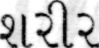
શરીર
